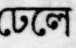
ঢেলে
